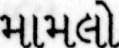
મામલો
